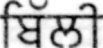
ਬਿੱਲੀ
